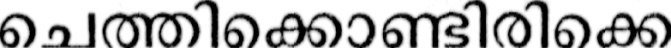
ചെത്തിക്കൊണ്ടിരിക്കെ
